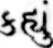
કહ્યું
